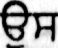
ਉਸ
